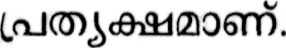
പ്രത്യക്ഷമാണ്.
